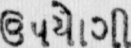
ઉપયોગી
